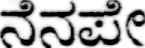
ನೆನಪೇ
